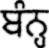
ਬੰਨ੍ਹ
